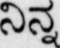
ನಿನ್ನ
